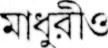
মাধুরীও
